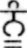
ਨੂੰ
